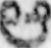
ಆ
